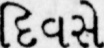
દિવસે
